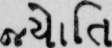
જ્યોતિ
